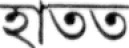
হাতত
